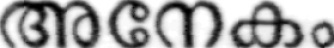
അനേകം
